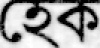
হেক
